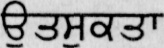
ਉਤਸੁਕਤਾ
